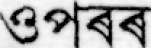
ওপৰৰ
